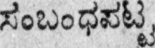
ಸಂಬಂಧಪಟ್ಟ
